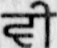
ਵੀ
